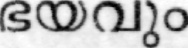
ഭയവും
